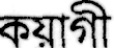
কয়াগী
